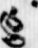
હું
